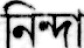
নিন্দা
